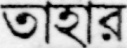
তাহার
